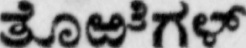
ತೊಱೆಗಳ್
